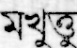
মখুত্তু
